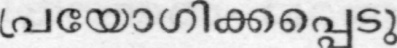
പ്രയോഗിക്കപ്പെടു
